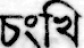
চংখি
